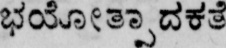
ಭಯೋತ್ಪಾದಕತೆ
